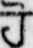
ਹੋ
